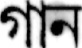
গান
